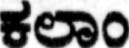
ಕಲಾ೦
